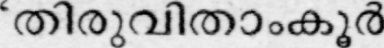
'തിരുവിതാംകൂര്‍
